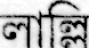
লাল্লি
